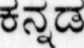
ಕನ್ನಡ
